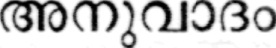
അനുവാദം
